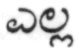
ಎಲ್ಲ
